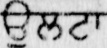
ਉਲਟਾ
